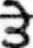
ਤੇ
